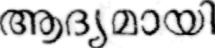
ആദ്യമായി
